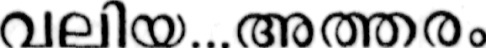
വലിയ...അത്തരം
